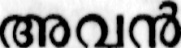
അവന്‍
